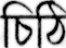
চিঠি
